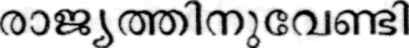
രാജ്യത്തിനുവേണ്ടി
